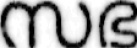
സഭ
